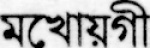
মখোয়গী
